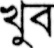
খুব
